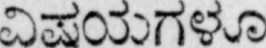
ವಿಷಯಗಳೂ
